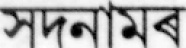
সদনামৰ
